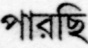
পারছি
